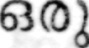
ഒരു
